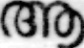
ആ
